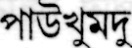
পাউখুমদু
